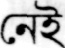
নেই
